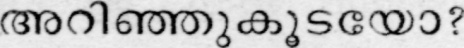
അറിഞ്ഞുകൂടയോ?
